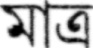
মাত্র
